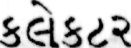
કલેકટર
